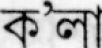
ক'লা
